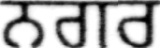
ਨਗਰ
